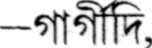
-গার্গীদি,
